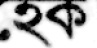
হেক
